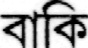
বাকি
